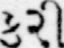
કરી
